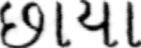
છાયા
